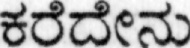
ಕರೆದೇನು
